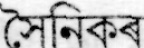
সৈনিকৰ
